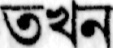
তখন
